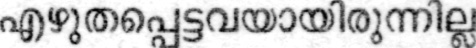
എഴുതപ്പെട്ടവയായിരുന്നില്ല
